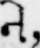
ને,
